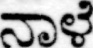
ನಾಳೆ
